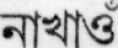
নাখাওঁ
